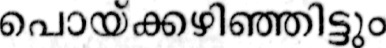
പൊയ്ക്കഴിഞ്ഞിട്ടും
